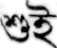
শুই
